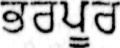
ਭਰਪੂਰ
